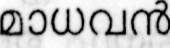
മാധവന്‍
